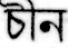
চীন
